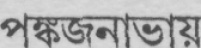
পঙ্কজনাভায়
